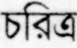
চরিত্র
